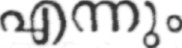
എന്നും
